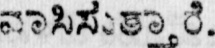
ವಾಸಿಸುತ್ತಾರೆ.
